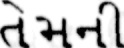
તેમની
